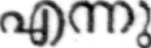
എന്നു
